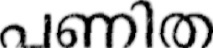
പണിത
